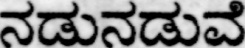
ನಡುನಡುವೆ
